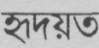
হৃদয়ত
